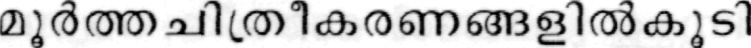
മൂര്‍ത്തചിത്രീകരണങ്ങളില്‍കൂടി
